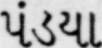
પંડ્યા
